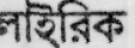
লাইরিক
